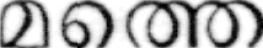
മത്തെ
